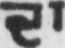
ਦਾ
